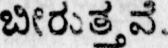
ಬೀರುತ್ತವೆ.
